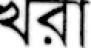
খরা
